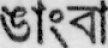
ঙাংবা
